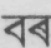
বৰ
